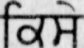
ਕਿਸੇ
